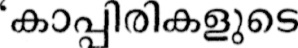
‘കാപ്പിരികളുടെ
